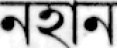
নহান
